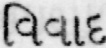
વિવાદ
